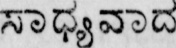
ಸಾಧ್ಯವಾದ
